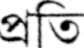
প্রতি
